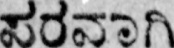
ಪರವಾಗಿ
